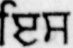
ਇਸ
